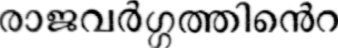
രാജവര്‍ഗ്ഗത്തിന്റെ
